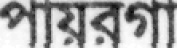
পায়রগা
